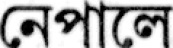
নেপালে
